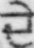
ਦੇ
